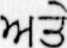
ਅਤੇ
